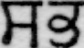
ਸਭ
